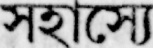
সহাস্যে
